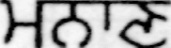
ਮਨਾਣ
